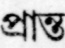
প্রান্ত
